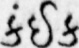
કંઈક
